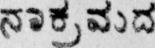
ನಾಕ್ರಮದ
